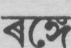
ৰঙ্গে
